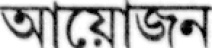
আয়োজন
